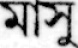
মাসু
